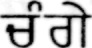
ਚੰਗੇ
